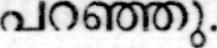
പറഞ്ഞു.
